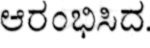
ಆರಂಭಿಸಿದ.
